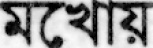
মখোয়
